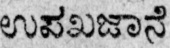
ಉಪಖಜಾನೆ
